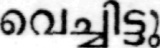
വെച്ചിട്ടു
